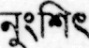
নুংশিৎ
